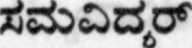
ಸಮವಿದ್ಯರ್
